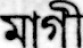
মাগী
